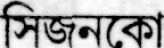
সিজনকো
